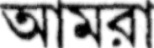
আমরা
